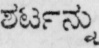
ಶರ್ಟನ್ನು
